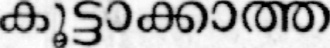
കൂട്ടാക്കാത്ത
